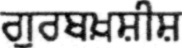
ਗੁਰਬਖ਼ਸ਼ੀਸ਼
